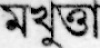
মখুত্তা
